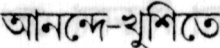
আনন্দে-খুশিতে
